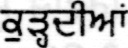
ਕੁੜ੍ਹਦੀਆਂ
